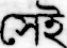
সেই
